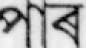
পাৰ
